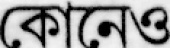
কোনেও
